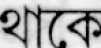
থাকে
